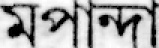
মপান্দা
